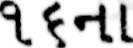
૧૬ના
